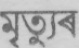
মৃত্যুৰ
